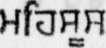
ਮਹਿਸੂਸ
